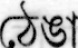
ঠেঙা
